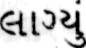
લાગ્યું
